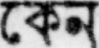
কেন
